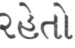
રહેતો
